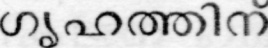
ഗൃഹത്തിന്
